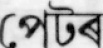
পেটৰ
